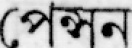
পেন্সন
